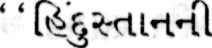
"હિંદુસ્તાનની
